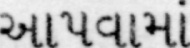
આપવામાં
